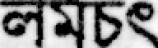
লমচৎ
